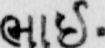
ભાઈ-
